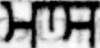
ਮਾਸ
